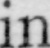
in
